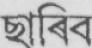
ছাৰিব
